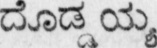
ದೊಡ್ಡಯ್ಯ
